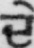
ਦੇ
